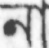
না
